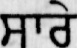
ਸਾਰੇ
